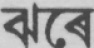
ঝৰে
